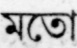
মতো
